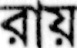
রায়
